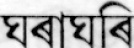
ঘৰাঘৰি
